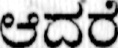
ಆದರೆ
